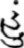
હું
